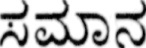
ಸಮಾನ
